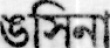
ঙসিনা
